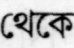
থেকে
